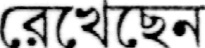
রেখেছেন
